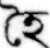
হৈ
